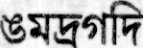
ঙমদ্রগদি
